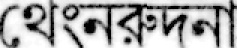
থেংনরুদনা
